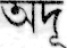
অদূ
